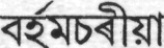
বর্হমচৰীয়া
